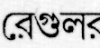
রেগুলর
